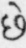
છે
